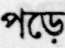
পড়ে
